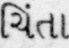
ચિંતા
